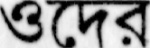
ওদের
